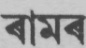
ৰামৰ
